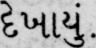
દેખાયું.
